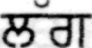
ਲੱਗ
